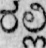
ರಲ್ಲಿ
